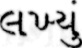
લખ્યું
